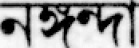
নঙ্গন্দা
